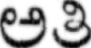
ಅತಿ
